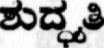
ಶುದ್ಧ್ಯತಿ
